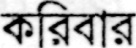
করিবার
